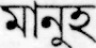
মানুহ
